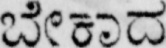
ಬೇಕಾದ
